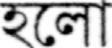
হলো
